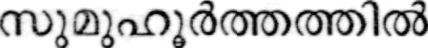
സുമുഹൂര്‍ത്തത്തില്‍
